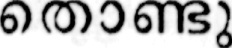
തൊണ്ടു
